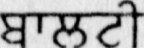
ਬਾਲਟੀ
